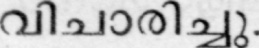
വിചാരിച്ചു.
